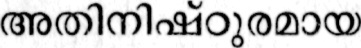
അതിനിഷ്ഠുരമായ
